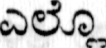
ಎಲ್ಲೊ
